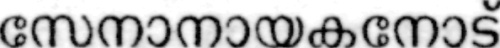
സേനാനായകനോട്
